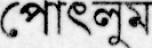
পুৎলুম
